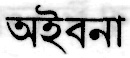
অইবনা
